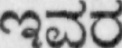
ಇವರ
